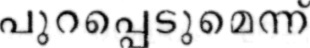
പുറപ്പെടുമെന്ന്
